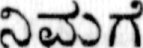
ನಿಮಗೆ
